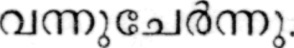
വന്നുചേര്‍ന്നു.
